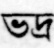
ভদ্র
